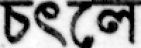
চৎলে
